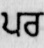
ਪਰ
